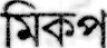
মিকপ
